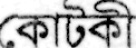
কোটকী
